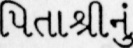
પિતાશ્રીનું
